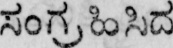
ಸಂಗ್ರಹಿಸಿದ
